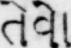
તેવો
